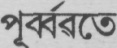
পূৰ্ব্বৱতে
